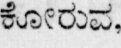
ಕೋರುವ,
